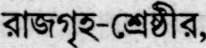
রাজগৃহ-শ্রেষ্ঠীর,
